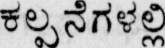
ಕಲ್ಪನೆಗಳಲ್ಲಿ
